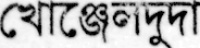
খোঞ্জেলদুদা
